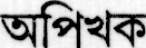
অপিখক
